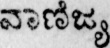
ವಾಣಿಜ್ಯ
